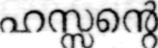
ഹസ്സന്റെ
